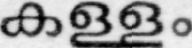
കള്ളം
